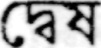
দ্বেষ
